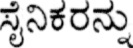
ಸೈನಿಕರನ್ನು
